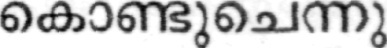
കൊണ്ടുചെന്നു
